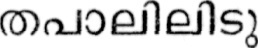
തപാലിലിടു
